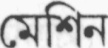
মেশিন
